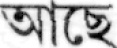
আছে
